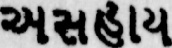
અસહાય
